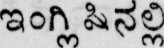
ಇಂಗ್ಲಿಷಿನಲ್ಲಿ
